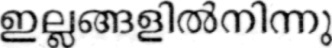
ഇല്ലങ്ങളില്‍നിന്നു
